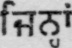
ਜਿਨ੍ਹਾਂ
